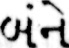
બંને
